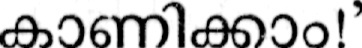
കാണിക്കാം!'
